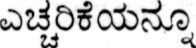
ಎಚ್ಚರಿಕೆಯನ್ನೂ
